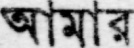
আমার
